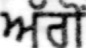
ਅੱਗੋਂ
